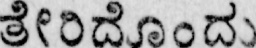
ತೇರಿದೊಂದು
